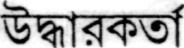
উদ্ধারকর্তা
